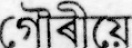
গৌৰীয়ে
